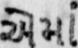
એમાં
